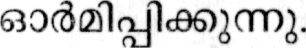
ഓര്‍മിപ്പിക്കുന്നു.
